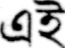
এই
